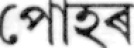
পোহৰ
